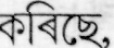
কৰিছে,
